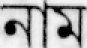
নাম
